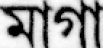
মাগা
